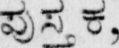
ಪುಸ್ತಕ,
